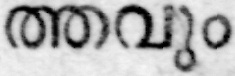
ത്തവും
